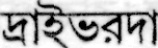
দ্রাইভরদা
